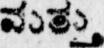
ಮತ್ತು
